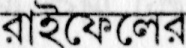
রাইফেলের
